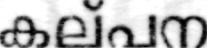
കല്പന
